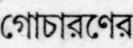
গোচারণের
